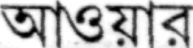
আওয়ার
